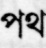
পথ
